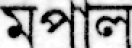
মপাল
